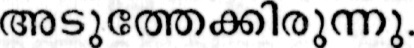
അടുത്തേക്കിരുന്നു.
